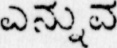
ಎನ್ನುವ
